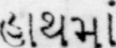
હાથમાં
